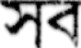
সব
